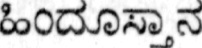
ಹಿಂದೂಸ್ತಾನ
